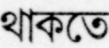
থাকতে
